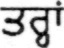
ਤਰ੍ਹਾਂ
